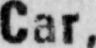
Car,
